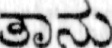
ತಾನು
